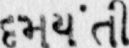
દમયંતી
